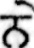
ਨੇ
